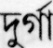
দুর্গা
